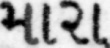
મારા
